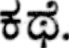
ಕಥೆ.
